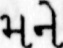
મને
